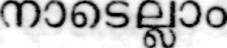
നാടെല്ലാം
